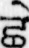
ਛੇ
